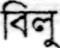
বিলু
